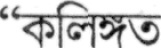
"কলিঙ্গত
